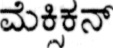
ಮೆಕ್ಸಿಕನ್
